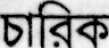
চারিক
